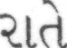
રાતે
